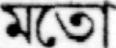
মতো
